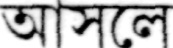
আসলে
